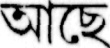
আছে
